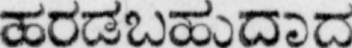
ಹರಡಬಹುದಾದ
